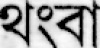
থংবা
